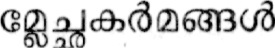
മ്ലേച്ഛകര്‍മങ്ങള്‍
